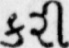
કરી
